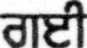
ਗਈ
